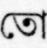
তো
